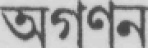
অগণন
